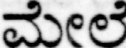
ಮೇಲೆ
